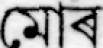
মোৰ
